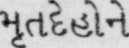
મૃતદેહોને
